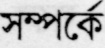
সম্পর্কে
